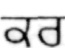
ਕਰ
